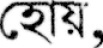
হোয়,
